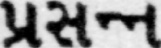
પ્રસન્ન
